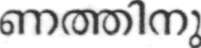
ണത്തിനു
